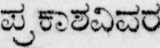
ಪ್ರಕಾಶವಿವರ
